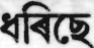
ধৰিছে
